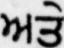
ਅਤੇ
